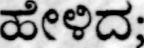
ಹೇಳಿದ;
